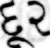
દૂર
